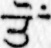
ਤੋਂ
